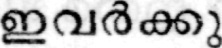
ഇവര്‍ക്കു
